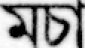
মচা
